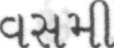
વસમી
